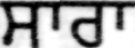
ਸਾਰਾ
